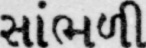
સાંભળી
